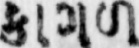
કાગળ
